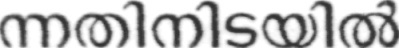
ന്നതിനിടയില്‍
